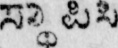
ಸ್ಥಾಪಿಸಿ
